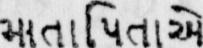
માતાપિતાએ
